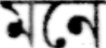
মনে
